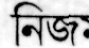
নিজম
